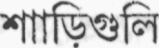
শাড়িগুলি
